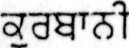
ਕੁਰਬਾਨੀ
